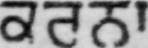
ਕਰਨਾ
